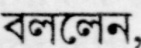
বললেন,
